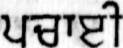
ਪਚਾਈ
